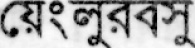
য়েংলুরবসু
